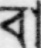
বা
